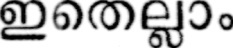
ഇതെല്ലാം
